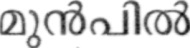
മുന്‍പില്‍
